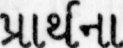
પ્રાર્થના
